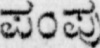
ಪಂಪು
